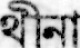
থীনা
